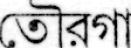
তৌরগা
